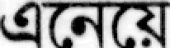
এনেয়ে
